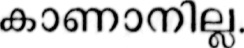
കാണാനില്ല.
